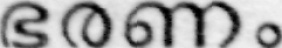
ഭരണം
